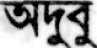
অদুবু
